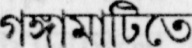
গঙ্গামাটিতে
